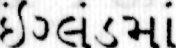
ઈંગ્લંડમાં
